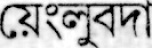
য়েংলুবদা
